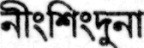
নীংশিংদুনা
